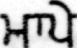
ਮਾਪੇ
